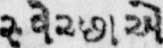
સ્વેચ્છાએ
